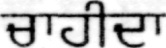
ਚਾਹੀਦਾ
